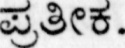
ಪ್ರತೀಕ.
